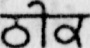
ਠੀਕ
